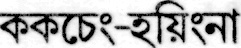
ককচেং-হয়িংনা
